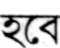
হবে
